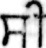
ਸੀ
